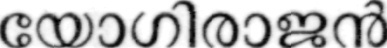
യോഗിരാജന്‍
